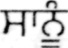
ਸਾਨੂੰ
